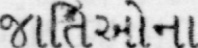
જાતિઓના
